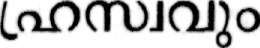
ഹ്രസ്വവും
